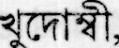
খুদোম্বী,
